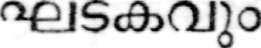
ഘടകവും
